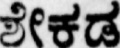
ಶೇಕಡ
